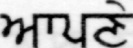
ਆਪਣੇ
